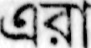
এরা
